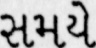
સમયે
